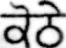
ਕੋਠੇ
